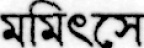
মমিৎসে
